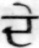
ਦੇ
